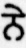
ਨੇ
